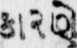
કારણે
